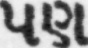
પણ
